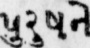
પુરુષને
